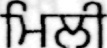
ਮਿਲੀ
